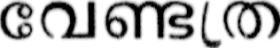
വേണ്ടത്ര
